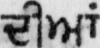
ਦੀਆਂ
